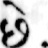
છે.
